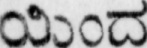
ಯಿಂದ
